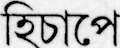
হিচাপে
